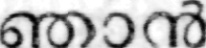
ഞാന്‍
